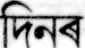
দিনৰ
